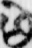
છે
